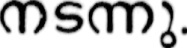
നടന്നു.
